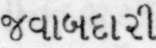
જવાબદારી
